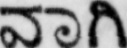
ವಾಗಿ
